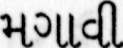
મગાવી
